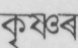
কৃষ্ণৰ
